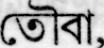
তৌবা,
